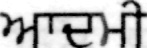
ਆਦਮੀ
